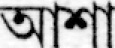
আশা
